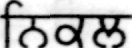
ਨਿਕਲ
